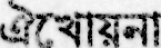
ঐখোয়না
